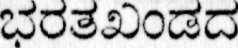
ಭರತಖಂಡದ
